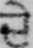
ਦੇ
